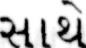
સાથે
